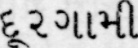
દૂરગામી
